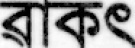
ৱাকৎ
